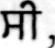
ਸੀ,
